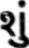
શું
